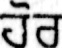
ਹੋਰ
